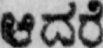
ಆದರೆ
